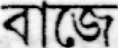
বাজে
